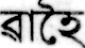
ৱাহৈ
